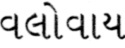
વલોવાય
